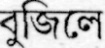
বুজিলে
